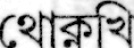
থোক্নখি
